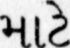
માટે
